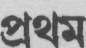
প্ৰথম
